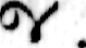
જ.
